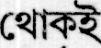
থোকই
